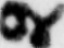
જ
